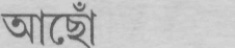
আছোঁ
